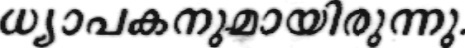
ധ്യാപകനുമായിരുന്നു.
